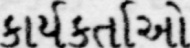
કાર્યકર્તાઓ
